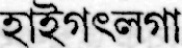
হাইগৎলগা
